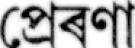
প্রেৰণা
